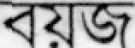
বয়জ
